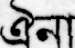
ঐনা
